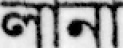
লানা
